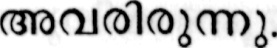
അവരിരുന്നു.
